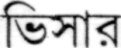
ভিসার
